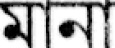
মানা
